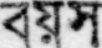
বয়স
